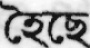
হৈছে
